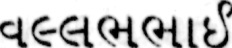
વલ્લભભાઈ
